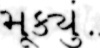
મૂક્યું.
